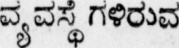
ವ್ಯವಸ್ಥೆಗಳಿರುವ
